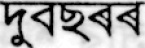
দুবছৰৰ
